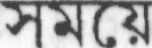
সময়ে
